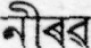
নীৰৱ
